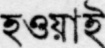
হওয়াই
